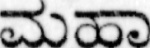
ಮಹಾ
